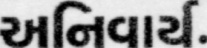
અનિવાર્ય.
